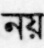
নয়
